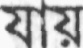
যায়
